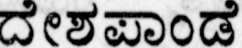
ದೇಶಪಾಂಡೆ
